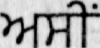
ਅਸੀਂ
